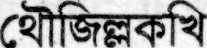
থৌজিল্লকখি
